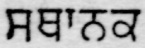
ਸਥਾਨਕ
